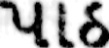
પાઠ
